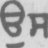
ਉਸ
